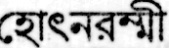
হোৎনরম্মী
